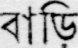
বাড়ি
